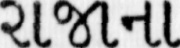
રાજાના
